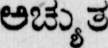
ಅಚ್ಯುತ
